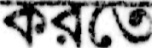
করতে
